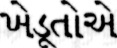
ખેડૂતોએ
